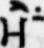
ਮੈਂ
